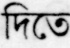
দিতে
